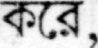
করে,
